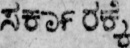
ಸರ್ಕಾರಕ್ಕೆ
